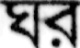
ঘর
